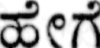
ಹೇಗೆ
